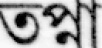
তপ্না
